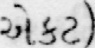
એકટ)
